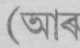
(আৰু
